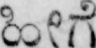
ಹೀಗೆ
